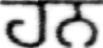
ਹਨ
